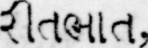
રીતભાત,
